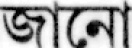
জানো
